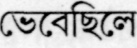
ভেবেছিলে
